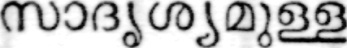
സാദ്യശ്യമുള്ള
